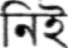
নিই
